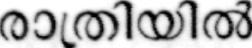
രാത്രിയില്‍
